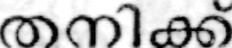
തനിക്ക്
